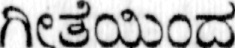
ಗೀತೆಯಿಂದ
